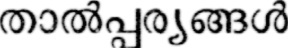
താല്‍പ്പര്യങ്ങള്‍
